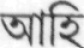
আহি
